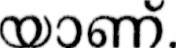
യാണ്.
